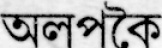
অলপকৈ
